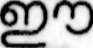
ഈ
